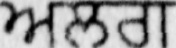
ਅਲਗ
